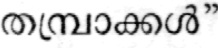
തമ്പ്രാക്കള്‍”
